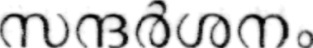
സന്ദര്‍ശനം
